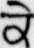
ਕੇ
